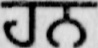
ਹਨ
